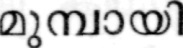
മുമ്പായി
